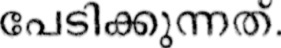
പേടിക്കുന്നത്.
